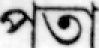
পতা
